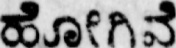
ಹೋಗಿವೆ
